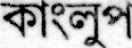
কাংলুপ
